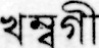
খম্বগী
